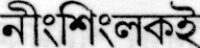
নীংশিংলকই
